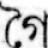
গৈ
